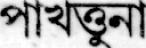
পাখত্তুনা
